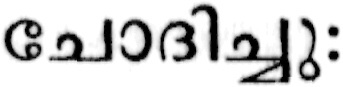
ചോദിച്ചു:
